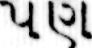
પણ
